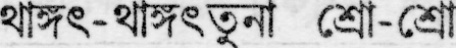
থাঙ্গৎ-থাঙ্গৎতুনা
